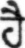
ਹੈ
